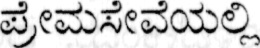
ಪ್ರೇಮಸೇವೆಯಲ್ಲಿ
